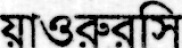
য়াওরুরসি
